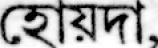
হোয়দা,
